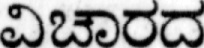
ವಿಚಾರದ
